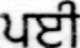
ਪਈ
